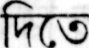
দিতে
